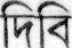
দিবি
